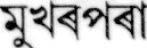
মুখৰপৰা
